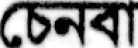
চেনবা
